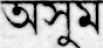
অসুম
